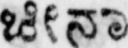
ಚೀನಾ
